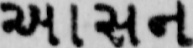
આસન
